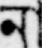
না
